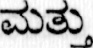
ಮತ್ತು
